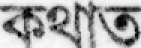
কথাত
